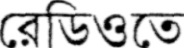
রেডিওতে
